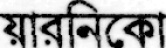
য়ারনিকো
